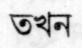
তখন
